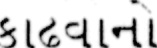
કાઢવાનો
